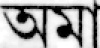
অমা
